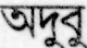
অদুবু
